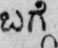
ಬಗ್ಗೆ
